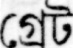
গ্রেট
